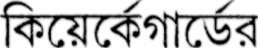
কিয়ের্কেগার্ডের
